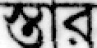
স্তার
